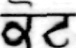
ਕੋਟ
